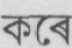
কৰে
